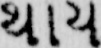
થાય
